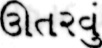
ઊતરવું
